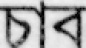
চাব
